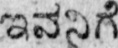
ಇವನಿಗೆ
